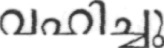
വഹിച്ചു
